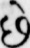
છે
